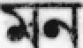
মন
